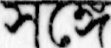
সঙ্গে
